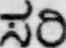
ಸರಿ
